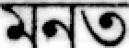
মনত
